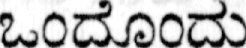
ಒಂದೊಂದು
